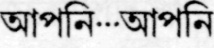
আপনি...আপনি
